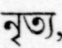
নৃত্য,
